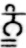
ਨੂੰ
